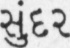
સુંદર
